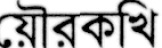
য়ৌরকখি
